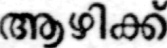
ആഴിക്ക്
